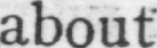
about
